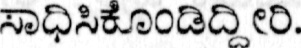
ಸಾಧಿಸಿಕೊಂಡಿದ್ದೀರಿ.
